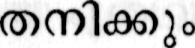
തനിക്കും
